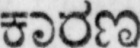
ಕಾರಣ
